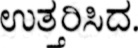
ಉತ್ತರಿಸಿದ.
